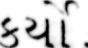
કર્યો.
